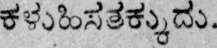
ಕಳುಹಿಸತಕ್ಕುದು.
